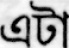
এটা
